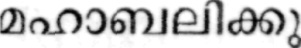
മഹാബലിക്കു
